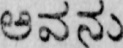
ಅವನು
